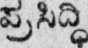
ಪ್ರಸಿದ್ಧಿ
